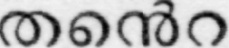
തന്റെ
